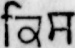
ਕਿਸ
